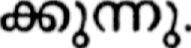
ക്കുന്നു.
